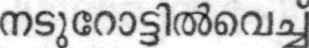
നടുറോട്ടില്‍വെച്ച്
